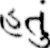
હતું
